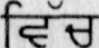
ਵਿੱਚ
